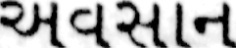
અવસાન
